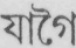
যাগৈ
